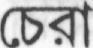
চেরা
